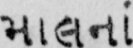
માલનાં
